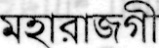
মহারাজগী
